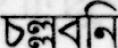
চল্লবনি
